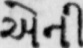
એની
